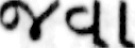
જવા
